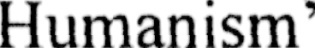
Humanism'
